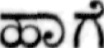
ಹಾಗೆ
